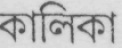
কালিকা
